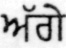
ਅੱਗੇ
